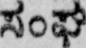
ಸಂಘ
